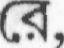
রে,
